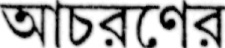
আচরণের
